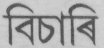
বিচাৰি
